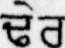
ਢੇਰ
